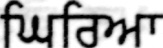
ਘਿਰਿਆ
